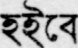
হইবে
